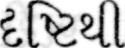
દૃષ્ટિથી
